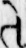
તે
